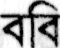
ববি
